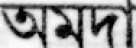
অমদা
